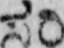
ಸರಿ
